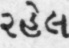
રહેલ
